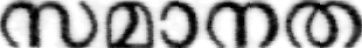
സമാനത
